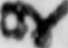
જ
